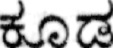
ಕೂಡ
